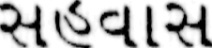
સહવાસ
